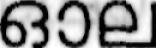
ഓല
